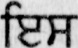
ਇਸ
